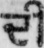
ਦੀ
